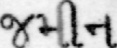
જમીન
